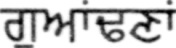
ਗੁਆਂਢਣਾਂ
